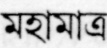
মহামাত্র
